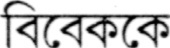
বিবেককে
